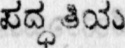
ಪದ್ಧತಿಯ
